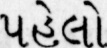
પહેલો
